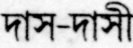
দাস-দাসী
